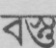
বস্তু
